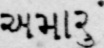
અમારું
